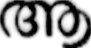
ആ
